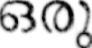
ഒരു
